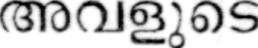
അവളുടെ
